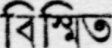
বিস্মিত
